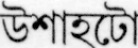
উশাহটো
